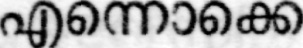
എന്നൊക്കെ
